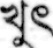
খুৎ
